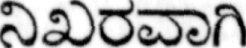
ನಿಖರವಾಗಿ
